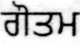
ਗੋਤਮ
